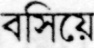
বসিয়ে
